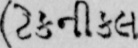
(ટેકનીકલ
